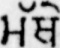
ਮੱਥੇ
